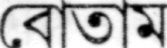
বোতাম
